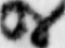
જ
